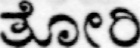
ತೋರಿ
